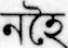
নহৈ
